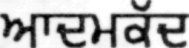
ਆਦਮਕੱਦ
